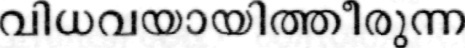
വിധവയായിത്തീരുന്ന
